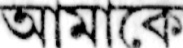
আমাকে
